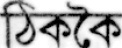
ঠিককৈ
